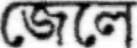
জেলে
